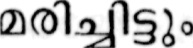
മരിച്ചിട്ടും
